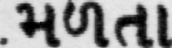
મળતા
